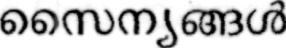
സൈന്യങ്ങള്‍
